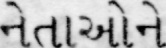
નેતાઓને
